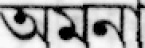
অমনা
